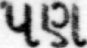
પણ
